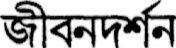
জীবনদর্শন
